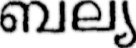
ബല്യ
